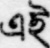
এই
